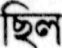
ছিল
